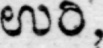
ಉರಿ,
